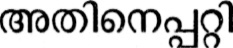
അതിനെപ്പറ്റി
